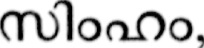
സിംഹം,
